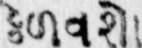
કેળવશો
